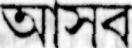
আসব
